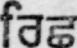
ਰਿਛ
